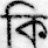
কি
